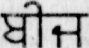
ਬੀਜ
